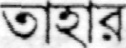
তাহার
